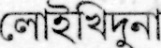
লোইখিদুনা
